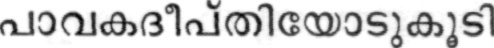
പാവകദീപ്തിയോടുകൂടി
